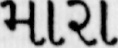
મારા
